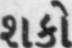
શકો
